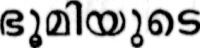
ഭൂമിയുടെ
